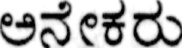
ಅನೇಕರು
